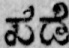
ಪಡೆ
